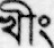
খীং
